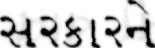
સરકારને
